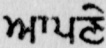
ਆਪਣੇ
